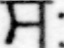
ਸ:
